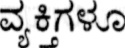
ವ್ಯಕ್ತಿಗಳೂ
